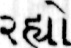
રહ્યો
